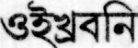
ওইখ্রবনি
